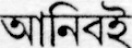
আনিবই
